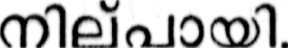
നില്പായി.
